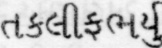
તકલીફભર્યુ
